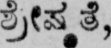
ಶ್ರೇಷ್ಠತೆ,
